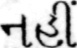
નહીં
